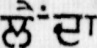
ਲੈਂਦਾ
